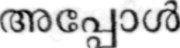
അപ്പോള്‍
